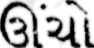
ઊંચો
